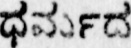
ಧರ್ಮದ
